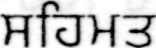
ਸਹਿਮਤ
